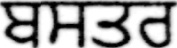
ਬਸਤਰ
